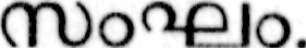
സംഘം.
